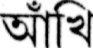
আঁখি
